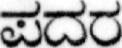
ಪದರ
